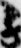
કે
